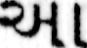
આ
